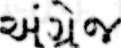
અંગ્રેજ
